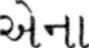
એના
